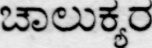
ಚಾಲುಕ್ಯರ
